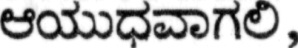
ಆಯುಧವಾಗಲಿ,
